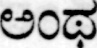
ಅಂಥ
